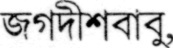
জগদীশবাবু,
